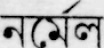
নর্মেল
